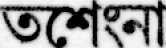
তশেংনা
